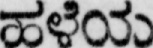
ಹಳೆಯ
